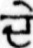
ਦੇ
